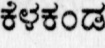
ಕೆಳಕಂಡ
